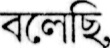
বলেছি,
